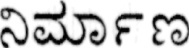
ನಿರ್ಮಾಣ
